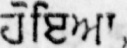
ਹੋਇਆ,
